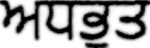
ਅਧਭੁਤ
